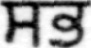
ਸਭ
